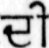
ਦੀ
